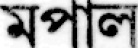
মপাল
